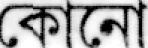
কোনো
